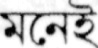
মনেই
